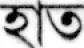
হাত
